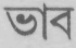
ভাব
